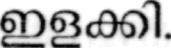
ഇളക്കി.
